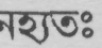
নহ্যতঃ
